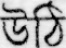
উঠি
